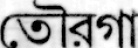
তৌরগা
